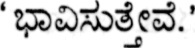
'ಭಾವಿಸುತ್ತೇವೆ.'
